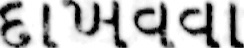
દાખવવા
